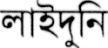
লাইদুনি
